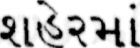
શહેરમાં
